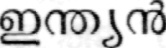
ഇന്ത്യന്‍
